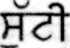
ਸੁੱਟੀ
